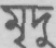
মৃদু
